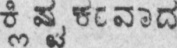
ಕ್ಲಿಷ್ಟಕರವಾದ
